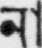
না
